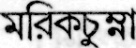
মরিকচুম্না
